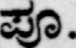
ಪೂ.
